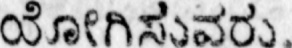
ಯೋಗಿಸುವರು.
